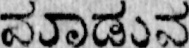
ಮಾಡುವ
